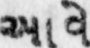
આવે
